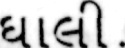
ઘાલી.
